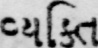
વ્યક્તિ
